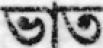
ভাত
